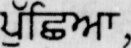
ਪੁੱਛਿਆ,
